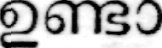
ഉണ്ടാ
